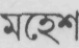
মহেশ
